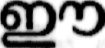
ഈ
